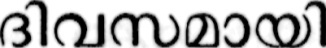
ദിവസമായി
